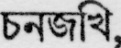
চনজখি,
